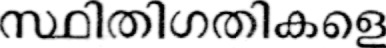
സ്ഥിതിഗതികളെ
